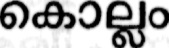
കൊല്ലം
